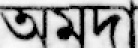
অমদা
